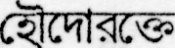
হৌদোরক্তে
